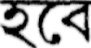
হবে
